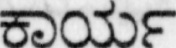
ಕಾರ್ಯ
